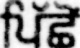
ਪਿੱਛੋਂ
